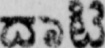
ದಾಟಿ
